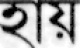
হায়
